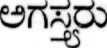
ಅಗಸ್ತ್ಯರು
